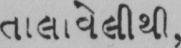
તાલાવેલીથી,
